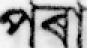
পৰা
